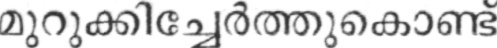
മുറുക്കിച്ചേര്‍ത്തുകൊണ്ട്
